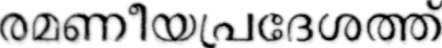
രമണീയപ്രദേശത്ത്
